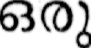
ഒരു
